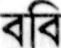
ববি
